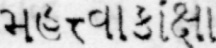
મહત્વકાંક્ષા
